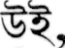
উই,
